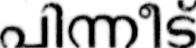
പിന്നീട്
